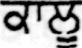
ਕਾਲੂ
